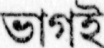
ভাগই
